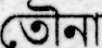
তৌনা
